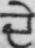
ਦੇ
